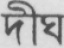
দীঘ
